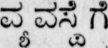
ವ್ಯವಸ್ಥೆಗೆ
